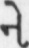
ને
